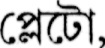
প্লেটো,
